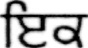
ਇਕ
